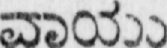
ವಾಯು
